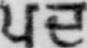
ਪਦ
